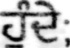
ਹੁੰਦੇ;
